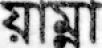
য়াম্না
